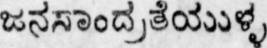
ಜನಸಾಂದ್ರತೆಯುಳ್ಳ
